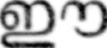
ഈ
